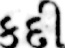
કદી
